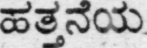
ಹತ್ತನೆಯ
